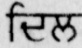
ਦਿਲ
